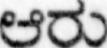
ಆರು
